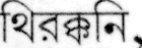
থিরক্কনি,
